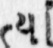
ત્યાં
